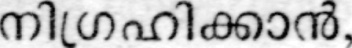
നിഗ്രഹിക്കാന്‍,
